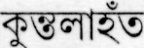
কুন্তলাহঁত
